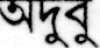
অদুবু
